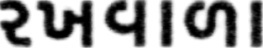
રખવાળા
